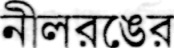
নীলরঙের
